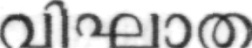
വിഘാത
